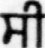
ਸੀ
